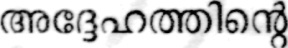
അദ്ദേഹത്തിന്റെ
